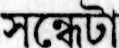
সন্ধেটা
